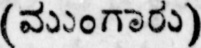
(ಮುಂಗಾರು)
